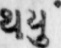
થયું
